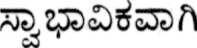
ಸ್ವಾಭಾವಿಕವಾಗಿ
